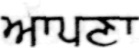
ਆਪਣਾ
